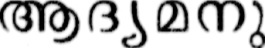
ആദ്യമനു
